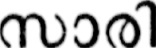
സാരി
